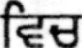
ਵਿਚ
